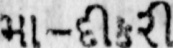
મા-દીકરી
